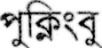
পুক্নিংবু
